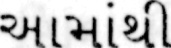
આમાંથી
